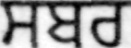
ਸਬਰ
